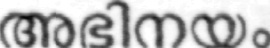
അഭിനയം
